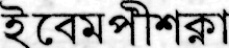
ইবেমপীশক্না
